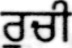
ਰੁਚੀ
